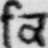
ਕਿ
